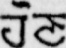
ਹੋਣ
